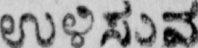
ಉಳಿಸುವ
